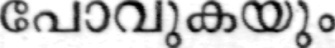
പോവുകയും
